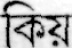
কিয়
